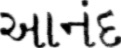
આનંદ
